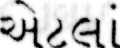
એટલાં
